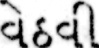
વેઠવી
